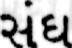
સંઘ
